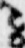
કે
